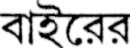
বাইরের
